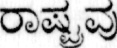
ರಾಷ್ಟ್ರವು
